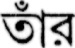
তাঁর
